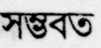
সম্ভবত
